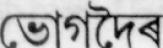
ভোগদৈৰ
